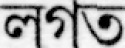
লগত
